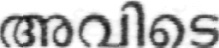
അവിടെ
